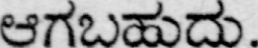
ಆಗಬಹುದು.
